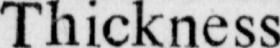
Thickness
